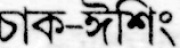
চাক-ঈশিং
